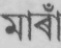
মাৰাঁ
